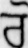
ਰੋ
